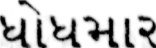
ધોધમાર
